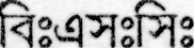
বিঃএসঃসিঃ
